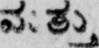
ಮತ್ತು
